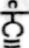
ਨੂੰ
